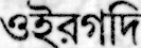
ওইরগদি
